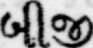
બીજી
